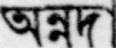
অন্নদা
